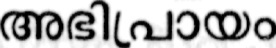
അഭിപ്രായം
